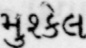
મુશ્કેલ
